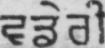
ਵਡੇਰੀ
